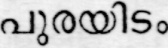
പുരയിടം
